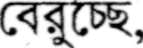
বেরুচ্ছে,
